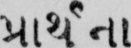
પ્રાર્થના
